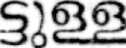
ട്ടുള്ള
